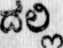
ದಲ್ಲಿ
